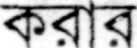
করার
